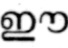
ഈ
